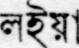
লইয়া
